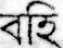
বহি
